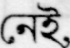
নেই,
